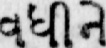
વધીને
